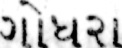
ગોધરા
